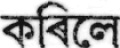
কৰিলে
